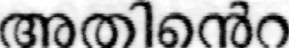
അതിന്റെ
